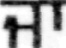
ਜਾ
